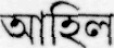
আহিল
